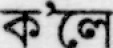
ক'লে
